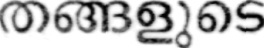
തങ്ങളുടെ
